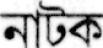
নাটক
